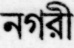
নগরী
